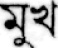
মুখ
